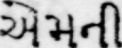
એમની
